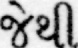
જેથી
